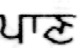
ਪਾਣ
